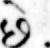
છે.
